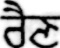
ਰੈਣ
